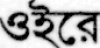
ওইরে
